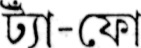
ট্যাঁ-ফো
